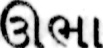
ઊભા
